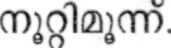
നൂറ്റിമൂന്ന്.
